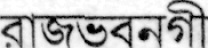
রাজভবনগী
